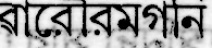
ৱারৌরমগনি
